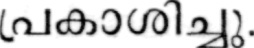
പ്രകാശിച്ചു.
